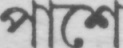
পাশে
